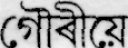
গৌৰীয়ে
